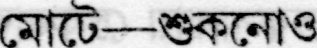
মোটে–শুকনোও
